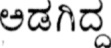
ಅಡಗಿದ್ದ
